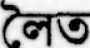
লৈত
